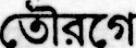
তৌরগে
